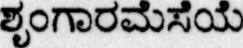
ಶೃಂಗಾರಮೆಸೆಯೆ
